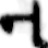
ન
